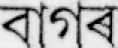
বাগৰ
